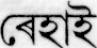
ৰেহাই
